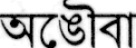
অঙৌবা
